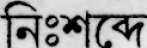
নিঃশব্দে
